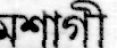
মশাগী
